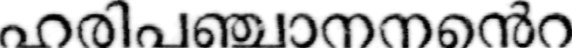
ഹരിപഞ്ചാനനന്റെ
